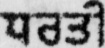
ਧਰਤੀ
